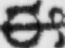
ಈ
